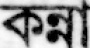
কন্না
